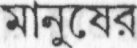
মানুষের
